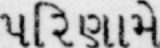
પરિણામે
